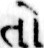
તો
